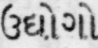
ઉધોગો
